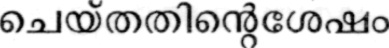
ചെയ്തതിന്റെശേഷം
